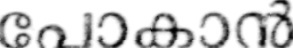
പോകാന്‍
